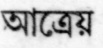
আত্রেয়
